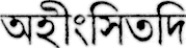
অহীংসিতদি
